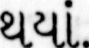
થયાં.
